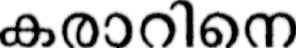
കരാറിനെ
